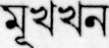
মূখখন
